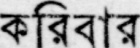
করিবার
